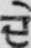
ਦੇ
